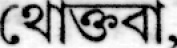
মরোল
